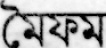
মৈফম
